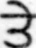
ਤੇ
